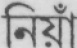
নিয়াঁ
